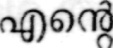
എന്റെ
